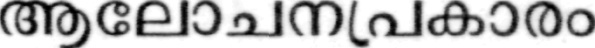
ആലോചനപ്രകാരം
